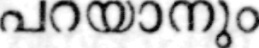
പറയാനും
